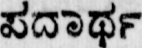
ಪದಾರ್ಥ
